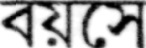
বয়সে
